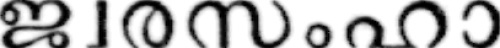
ജ്വരസംഹാ
